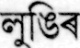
লুঙিৰ
